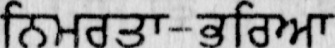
ਨਿਮਰਤਾ-ਭਰਿਆ
